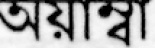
অয়াম্বা
